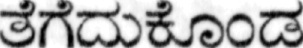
ತೆಗೆದುಕೊಂಡ
